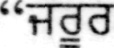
''ਜਰੂਰ
